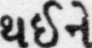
થઈને
